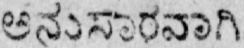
ಅನುಸಾರವಾಗಿ
